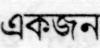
একজন
